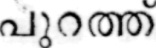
പുറത്ത്
